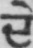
ਦੇ
